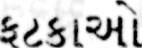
ફટકાઓ
